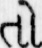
તો
